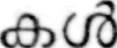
കള്‍
